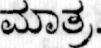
ಮಾತ್ರ.
